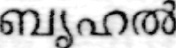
ബൃഹല്‍
